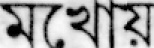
মখোয়
